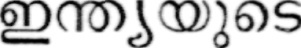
ഇന്ത്യയുടെ
